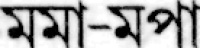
মমা-মপা
